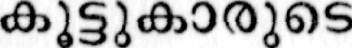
കൂട്ടുകാരുടെ
